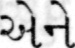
એને
